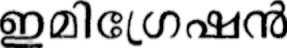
ഇമിഗ്രേഷന്‍
